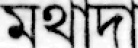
মথাদা
